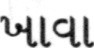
ખાવા
